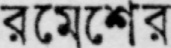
রমেশের
